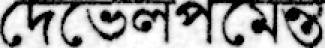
দেভেলপমেন্ত
